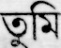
তুমি
